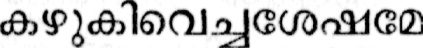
കഴുകിവെച്ചശേഷമേ
